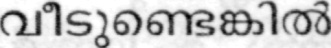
വീടുണ്ടെങ്കില്‍
